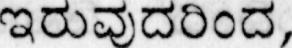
ಇರುವುದರಿಂದ,
